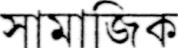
সামাজিক
